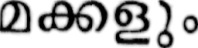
മക്കളും
